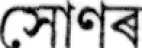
সোণৰ
